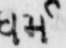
ધર્મ
